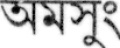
অমসুং
